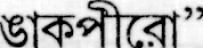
ঙাকপীরো”
